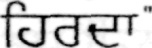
ਹਿਰਦਾ''
